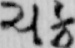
ચક્ર
